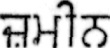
ਜ਼ਮੀਨ
